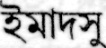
ইমাদসু
